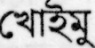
খোইমু
